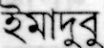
ইমাদুবু
